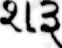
શરૂ
